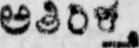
ಅತಿರಿಕ್ತ
